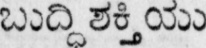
ಬುದ್ದಿಶಕ್ತಿಯು
